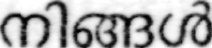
നിങ്ങള്‍
